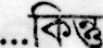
...কিন্তু
